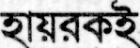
হায়রকই
